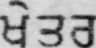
ਖੇਤਰ
